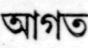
আগত
